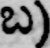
ಬ)
